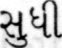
સુધી
